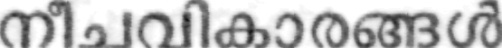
നീചവികാരങ്ങള്‍
